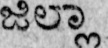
ಜಿಲ್ಲಾ
